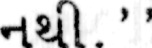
નથી."
